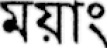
ময়াং
